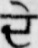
ਦੇ
